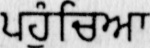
ਪਹੁੰਚਿਆ
